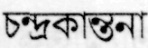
চন্দ্রকান্তনা
